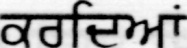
ਕਰਦਿਆਂ
